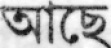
আছে
